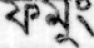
ফমুং
